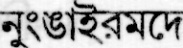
নুংঙাইরমদে
